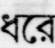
ধরে
